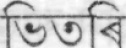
ভিতৰি
